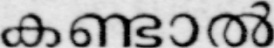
കണ്ടാല്‍
